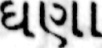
ઘણા
